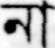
না
